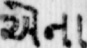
એના
